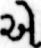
એ
